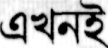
এখনই
